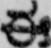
ಈ
